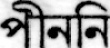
পীননি
